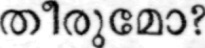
തീരുമോ?
